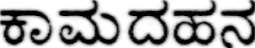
ಕಾಮದಹನ
